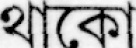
থাকো
